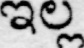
ಇಲ್ಲ
